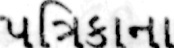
પત્રિકાના
